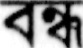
বন্ধ
